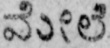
ಮೇಲೆ
